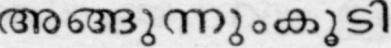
അങ്ങുന്നുംകൂടി
